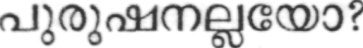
പുരുഷനല്ലയോ?
